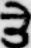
ਤੇ
